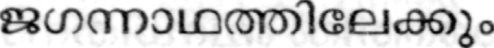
ജഗന്നാഥത്തിലേക്കും
